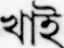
খাই
